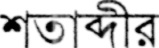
শতাব্দীর
